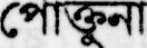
পোক্তুনা
